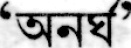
‘অনর্ঘ’
